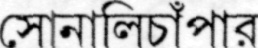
সোনালিচাঁপার
